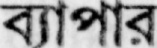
ব্যাপার
